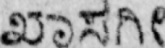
ಖಾಸಗೀ
